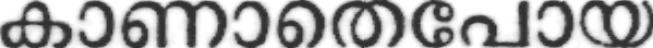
കാണാതെപോയ
